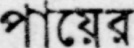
পায়ের
